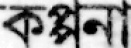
কপ্পনা
